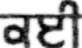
ਕਈ
